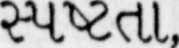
સ્પષ્ટતા,
